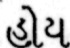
હોય
